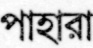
পাহারা
